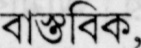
বাস্তবিক,
